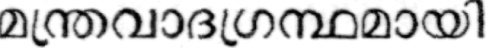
മന്ത്രവാദഗ്രന്ഥമായി
